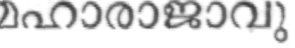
മഹാരാജാവു
